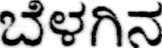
ಬೆಳಗಿನ
